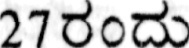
27ರಂದು
